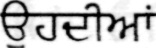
ਉਹਦੀਆਂ
